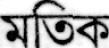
মতিক
